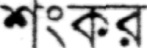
শংকর
